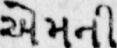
એમની
